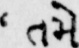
'તમે
